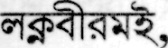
লক্নবীরমই,
